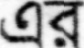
এর
